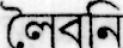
লৈবনি
